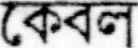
কেবল
